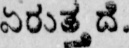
ಏರುತ್ತದೆ.
